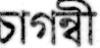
চাগন্বী
